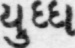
યુધ્ધ
